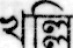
খল্লি
